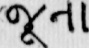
જૂના
